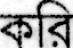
করি
